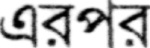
এরপর
